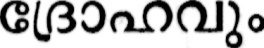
ദ്രോഹവും
